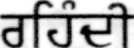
ਰਹਿੰਦੀ
